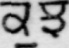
ਕੁਝ
